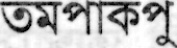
তমপাকপু
